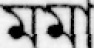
মমা
